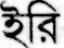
ইরি
